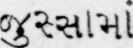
જુસ્સામાં
